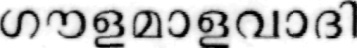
ഗൌളമാളവാദി
